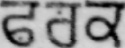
ਫਰਕ
